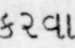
કરવા
